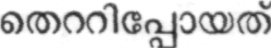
തെററിപ്പോയത്
